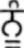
ਨੂੰ
